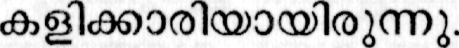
കളിക്കാരിയായിരുന്നു.
